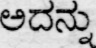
ಅದನ್ನು
